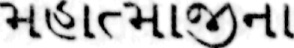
મહાત્માજીના
